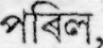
পৰিল,
